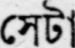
সেটা
